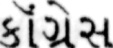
કૉંગ્રેસ
